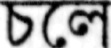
চলে
